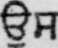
ਉਸ
